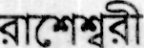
রাশেশ্বরী
